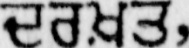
ਦਰਖ਼ਤ,
